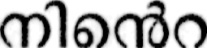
നിന്റെ
